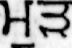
ਮੁੜ
